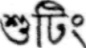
শুটিং
